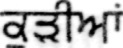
ਕੁੜੀਆਂ
